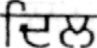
ਦਿਲ
